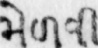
મેળવી
